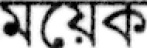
ময়েক
